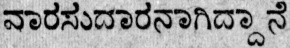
ವಾರಸುದಾರನಾಗಿದ್ದಾನೆ
